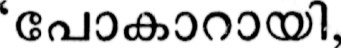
'പോകാറായി,
